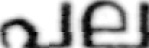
പല
